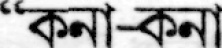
“কনা-কনা
